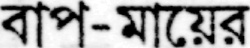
বাপ-মায়ের
